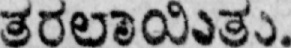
ತರಲಾಯಿತು.
